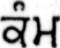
ਕੰਮ
